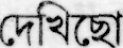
দেখিছো
